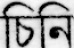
চিনি
